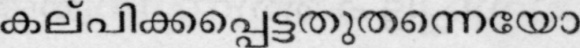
കല്പിക്കപ്പെട്ടതുതന്നെയോ
